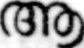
ആ
